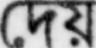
দেয়
